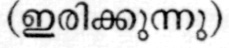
(ഇരിക്കുന്നു)
